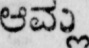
ಆಮ್ಲ
